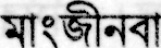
মাংজীনবা
